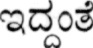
ಇದ್ದಂತೆ
